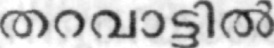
തറവാട്ടില്‍
